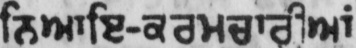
ਨਿਆਇ-ਕਰਮਚਾਰੀਆਂ
